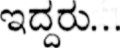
ಇದ್ದರು....
